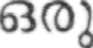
ഒരു
